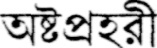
অষ্টপ্রহরী
